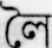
লৈ
